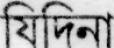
যিদিনা
